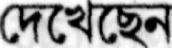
দেখেছেন
